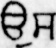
ਉਸ
